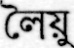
লৈয়ু
